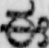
ಈ
